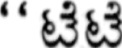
"ಟೆಟೆ
